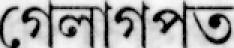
গেলাগপত
